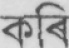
কৰি
